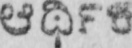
ಆರ್ಥಿಕ
